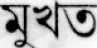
মুখত
